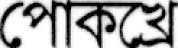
পোকখ্রে
